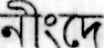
নীংদে
